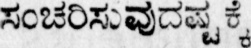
ಸಂಚರಿಸುವುದಷ್ಟಕ್ಕೆ
